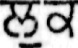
ਲੁਕ
